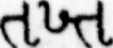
તખ્ત
